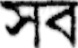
সব
